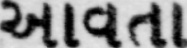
આવતા
